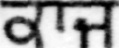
ਕਾਜ
